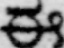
ಈ
